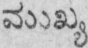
ಮುಖ್ಯ
